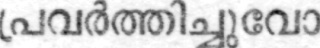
പ്രവര്‍ത്തിച്ചുവോ
